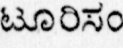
ಟೂರಿಸಂ
